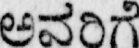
ಅವರಿಗೆ
